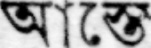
আস্তে
